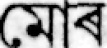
মোৰ
